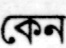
কেন
